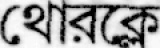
থোরক্লে
